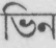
ভিন
